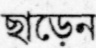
ছাড়েন
